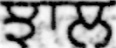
ਝਾਲ
